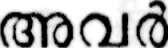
അവര്‍
